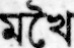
মখৈ
